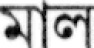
মাল
